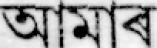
আমাৰ
